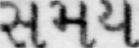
સમય
